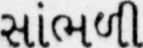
સાંભળી
